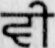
ਵੀ
